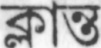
ক্লান্ত
